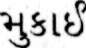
મુકાઈ
